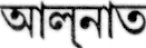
আলনাত
